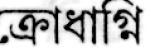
ক্রোধাগ্নি
